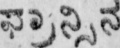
ಫ್ರಾನ್ಸಿನ
